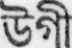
উগী
